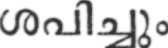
ശപിച്ചും
